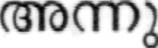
അന്നു
